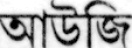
আউজি
